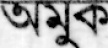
অমুক
